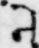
ને
